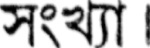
সংখ্যা।
